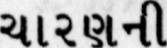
ચારણની
